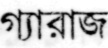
গ্যারাজ
